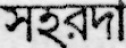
সহরদা
